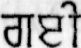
ਗਈ
